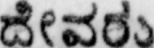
ದೇವರು
